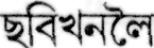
ছবিখনলৈ
